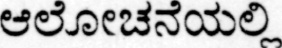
ಆಲೋಚನೆಯಲ್ಲಿ
